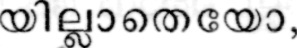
യില്ലാതെയോ,
